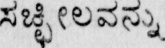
ಸಚ್ಛೀಲವನ್ನು
